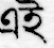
এই
